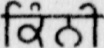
ਕਿੰਨੀ
